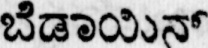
ಬೆಡಾಯಿನ್
